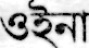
ওইনা
